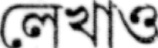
লেখাও
